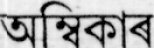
অম্বিকাৰ
